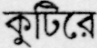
কুটিরে
